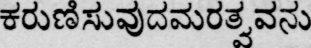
ಕರುಣಿಸುವುದಮರತ್ವವನು
